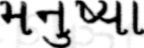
મનુષ્યા
